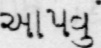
આપવું
